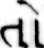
તો
